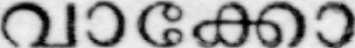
വാക്കോ
